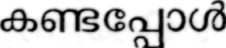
കണ്ടപ്പോള്‍
